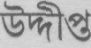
উদ্দীপ্ত
